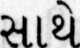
સાથે
